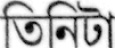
তিনিটা
